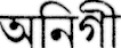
অনিগী
